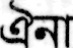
ঐনা
